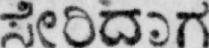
ಸೇರಿದಾಗ
